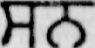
ਸਨ
